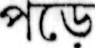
পড়ে
